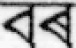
বৰ
